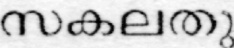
സകലതു
